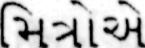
મિત્રોએ
